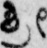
ಶ್ರೀ
